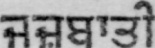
ਜਜ਼ਬਾਤੀ
